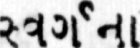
સ્વર્ગના
